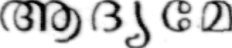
ആദ്യമേ
